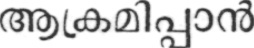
ആക്രമിപ്പാന്‍
